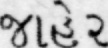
જાહેર
